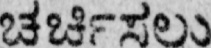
ಚರ್ಚಿಸಲು
